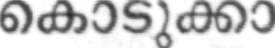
കൊടുക്കാ
